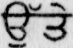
ਉੱਤੇ
